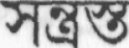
সন্ত্রস্ত
